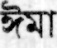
ঈমা
